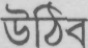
উঠিব
